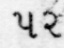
પર
